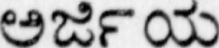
ಅರ್ಜಿಯ
